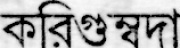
করিগুম্বদা
